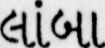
લાંબા
